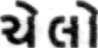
ચેલો
